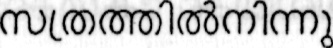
സത്രത്തില്‍നിന്നു
